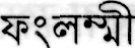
ফংলম্মী
